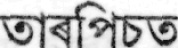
তাৰপিচত
